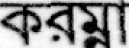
করম্না
